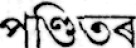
পণ্ডিতৰ
